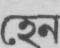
হেন
